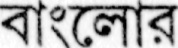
বাংলোর
